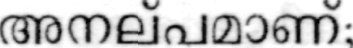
അനല്പമാണ്;
